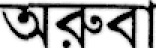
অরুবা
